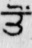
ਤੋਂ
